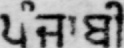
ਪੰਜਾਬੀ
